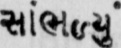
સાંભળ્યું
